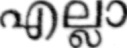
എല്ലാ
